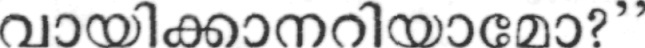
വായിക്കാനറിയാമോ?"
